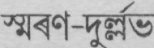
স্মৰণ-দুৰ্ল্লভ
